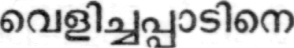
വെളിച്ചപ്പാടിനെ
